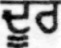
ਦੂਰ
